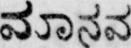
ಮಾನವ
